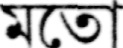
মতো
